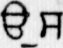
ਉਸ
